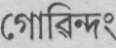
গোৱিন্দং
